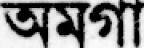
অমগা
